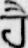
ਹੈ
